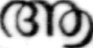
ആ
